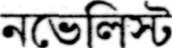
নভেলিস্ট
